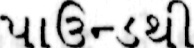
પાઉન્ડથી
